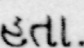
હતા.
